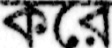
করে
